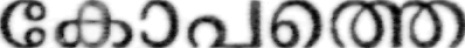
കോപത്തെ
